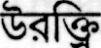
উরক্ত্রি
